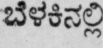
ಬೆಳಕಿನಲ್ಲಿ
